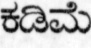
ಕಡಿಮೆ
